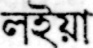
লইয়া
